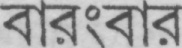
বারংবার
